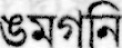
ঙমগনি
